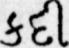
કદી
